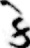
કે
